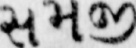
સમજી
